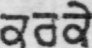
ਕਰਕੇ
